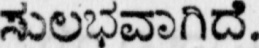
ಸುಲಭವಾಗಿದೆ.
